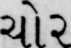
ચોર
